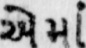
એમાં
